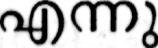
എന്നു
